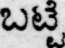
ಬಟ್ಟೆ
